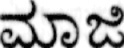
ಮಾಜಿ
